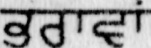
ਭਰਾਵਾਂ
